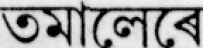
তমালেৰে
